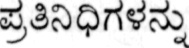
ಪ್ರತಿನಿಧಿಗಳನ್ನು
